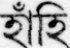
হাঁহি
